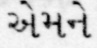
એમને
